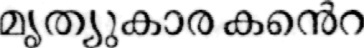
മൃത്യുകാരകന്റെ
